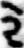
રે
